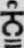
ਨੂੰ
